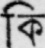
কি
